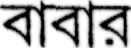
বাবার
